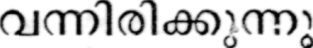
വന്നിരിക്കുന്നു
